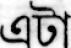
এটা
